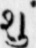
શું
